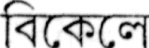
বিকেলে
